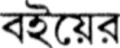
বইয়ের
